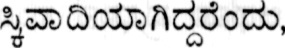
ಸ್ಕಿವಾದಿಯಾಗಿದ್ದರೆಂದು,
